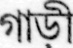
গাড়ী
